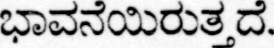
ಭಾವನೆಯಿರುತ್ತದೆ.
